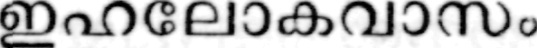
ഇഹലോകവാസം
